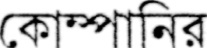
কোম্পানির
